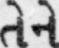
તેને
